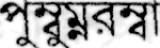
পুম্বুম্নরম্বা
